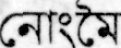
নোংমৈ
